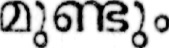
മുണ്ടും
